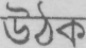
উঠক
